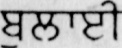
ਬੁਲਾਈ
